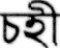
চহী
